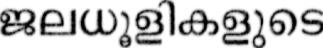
ജലധൂളികളുടെ
